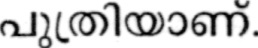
പുത്രിയാണ്.
